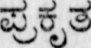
ಪ್ರಕೃತ
